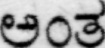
ಅಂತ
